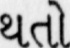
થતો
